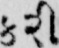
કરી
